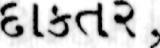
દાક્તર,
